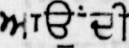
ਆਉਂਦੀ
